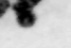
જ
